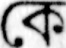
কে
